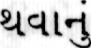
થવાનું
